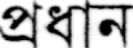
প্রধান
